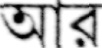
আর
